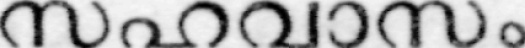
സഹവാസം
